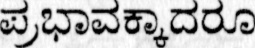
ಪ್ರಭಾವಕ್ಕಾದರೂ
